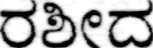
ರಶೀದ
